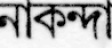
নাকন্দা
